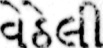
વેઠેલી
